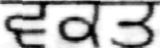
ਵਕਤ
